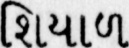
શિયાળ
